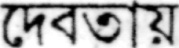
দেবতায়
